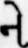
ને
